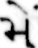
મેં
